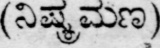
(ನಿಷ್ಕ್ರಮಣ)
